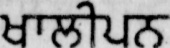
ਖਾਲੀਪਨ
